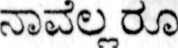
ನಾವೆಲ್ಲರೂ
